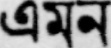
এমন
